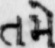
તમે
